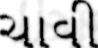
ચાવી
